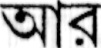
আর
